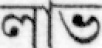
লাভ
